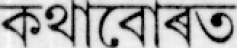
কথাবোৰত
